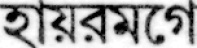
হায়রমগে
